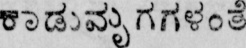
ಕಾಡುಮೃಗಗಳಂತೆ
